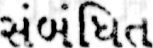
સંબંધિત
